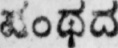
ಪಂಥದ
